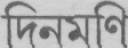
দিনমণি
